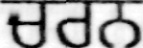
ਚਰਨ
